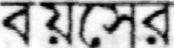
বয়সের
